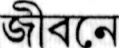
জীবনে
